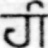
ਹੀ
